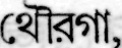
থৌবা,
